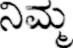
ನಿಮ್ಮ
